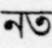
নত
